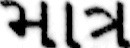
માત્ર
